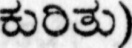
ಕುರಿತು)
